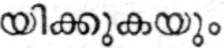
യിക്കുകയും
